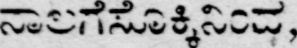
ನಾಲಗೆಸೂಕ್ಕಿನಿಂದ,
